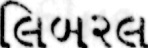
લિબરલ
